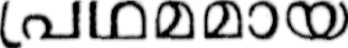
പ്രഥമമായ
